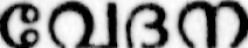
വേദന
